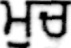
ਮੁਚ
